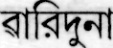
ৱারিদুনা
